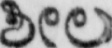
ಶೀಲ
